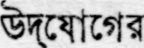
উদ্‌যোগের
